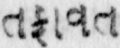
તફાવત
